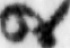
જ
